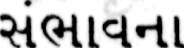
સંભાવના
